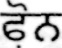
ਫ਼ੋਨ
